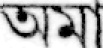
অমা
